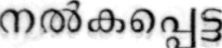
നല്‍കപ്പെട്ട
